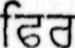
ਫਿਰ
